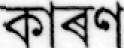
কাৰণ
